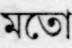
মতো
